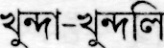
খুন্দা-খুন্দলি
